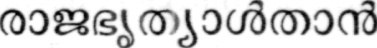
രാജഭൃത്യാള്‍താന്‍
